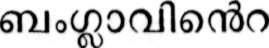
ബംഗ്ലാവിന്റെ
